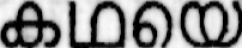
കഥയെ
